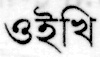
ওইখি
